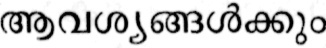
ആവശ്യങ്ങള്‍ക്കും
